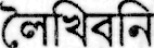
লৈখিবনি
